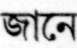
জানে
